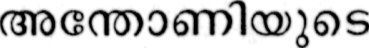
അന്തോണിയുടെ
